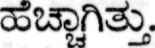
ಹೆಚ್ಚಾಗಿತ್ತು.
